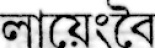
লায়েংবৈ
